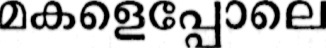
മകളെപ്പോലെ
